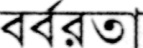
বর্বরতা
